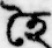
হৈ
